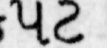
કપટ
